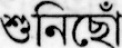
শুনিছোঁ
